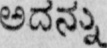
ಅದನ್ನು
